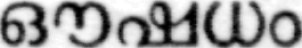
ഔഷധം
